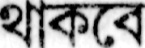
থাকবে
